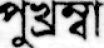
পুখ্রম্বা
